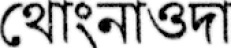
থোংনাওদা
